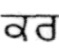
ਕਰ
